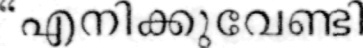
"എനിക്കുവേണ്ടി
